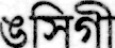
ঙসিগী
